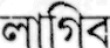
লাগিব
